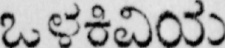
ಒಳಕಿವಿಯ
